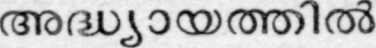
അദ്ധ്യായത്തില്‍
